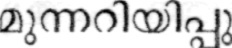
മുന്നറിയിപ്പു
